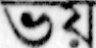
ভয়
